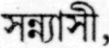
সন্ন্যাসী,
